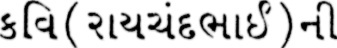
કવિ(રાયચંદભાઈ)ની
